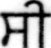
ਸੀ
